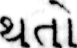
થતો
